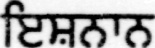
ਇਸ਼ਨਾਨ
